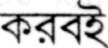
করবই
